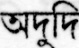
অদুদি
